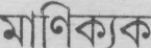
মাণিক্যক
